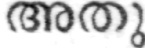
അതു
